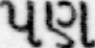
પણ
